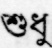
শুধু
